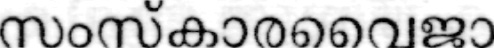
സംസ്കാരവൈജാ
